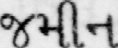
જમીન
